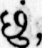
છું,
